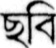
ছবি
